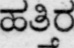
ಹತ್ತಿರ
